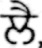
ਲੈ,
